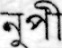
নুপী
